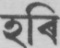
হৰি
